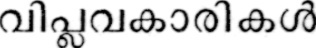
വിപ്ലവകാരികള്‍
